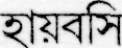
হায়বসি
